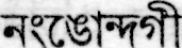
নংঙোন্দগী
